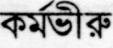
কর্মভীরু
